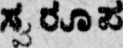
ಸ್ವರೂಪ
